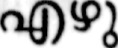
എഴു
